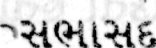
સભાસદ
